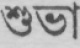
শুভা
